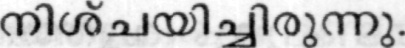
നിശ്ചയിച്ചിരുന്നു.
